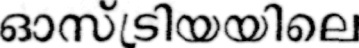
ഓസ്ട്രിയയിലെ
